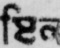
ਇਕ
